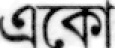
একো
